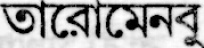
তারোমেনবু
